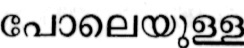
പോലെയുള്ള
